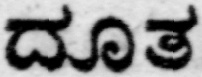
ದೂತ
